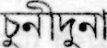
চুনীদুনা
